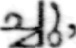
ച്ചു,
